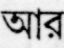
আর
